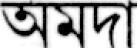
অমদা
